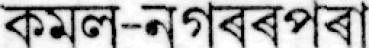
কমল-নগৰৰপৰা
